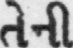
તેની
